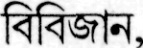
বিবিজান,
